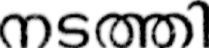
നടത്തി
